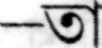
-তা
